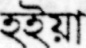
হইয়া
